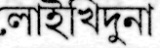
লোইখিদুনা
